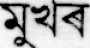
মুখৰ
